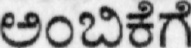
ಅಂಬಿಕೆಗೆ
